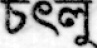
চৎলু
